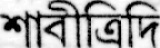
শাবীত্রিদি
